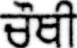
ਚੌਥੀ
